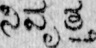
ನಿವೃತ್ತ
